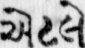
એટલે
